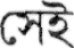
সেই
